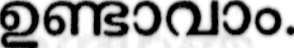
ഉണ്ടാവാം.
